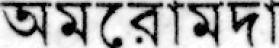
অমরোমদা
